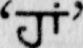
'ਹਾਂ'
